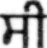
ਸੀ
